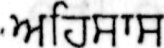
ਅਹਿਸਾਸ
